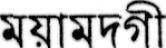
ময়ামদগী
